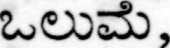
ಒಲುಮೆ,
